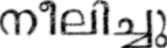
നീലിച്ചു
